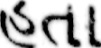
હતા
